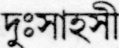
দুঃসাহসী
